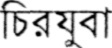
চিরযুবা
